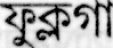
ফুক্লগা
